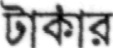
টাকার
